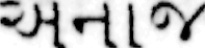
અનાજ
